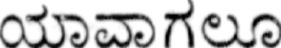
ಯಾವಾಗಲೂ
